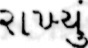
રાખ્યું
